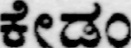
ಕೇಡಂ
